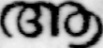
ആ
